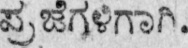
ಪ್ರಜೆಗಳಿಗಾಗಿ.
